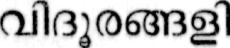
വിദൂരങ്ങളി
